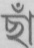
ছাঁ
